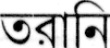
তরানি
